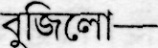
বুজিলো-
